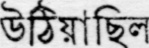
উঠিয়াছিল
